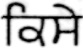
ਕਿਸੇ
